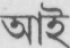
আই
